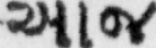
આજ
